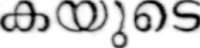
കയുടെ
